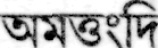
অমত্তংদি
